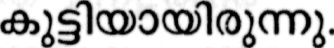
കുട്ടിയായിരുന്നു.
